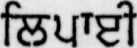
ਲਿਪਾਈ
